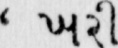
'ખરી
